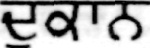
ਦੁਕਾਨ
